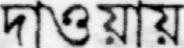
দাওয়ায়
